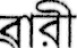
ৱারী
